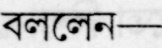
বললেন–
